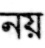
নয়
